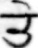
ਤੇ
